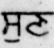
ਸੁਣ
